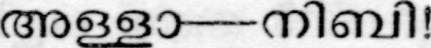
അള്ളാ-നിബി!
